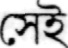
সেই
